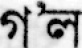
গ'ল
